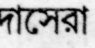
দাসেরা
